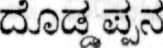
ದೊಡ್ಡಪ್ಪನ
